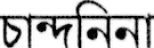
চান্দনিনা
